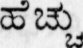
ಹೆಚ್ಚು
